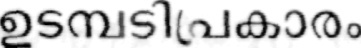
ഉടമ്പടിപ്രകാരം
